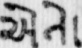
એનો
